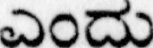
ಎಂದು
